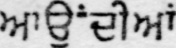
ਆਉਂਦੀਆਂ
